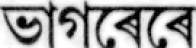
ভাগৰেৰে
